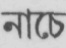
নাচে
